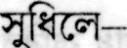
সুধিলে-
